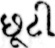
છૂટી
